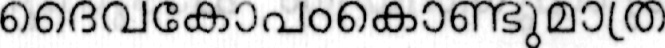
ദൈവകോപംകൊണ്ടുമാത്ര
